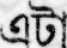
এটা
